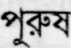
পুরুষ
